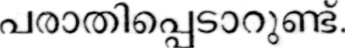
പരാതിപ്പെടാറുണ്ട്.
